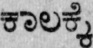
ಕಾಲಕ್ಕೆ
